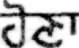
ਹੋਣਾ
